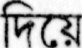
দিয়ে
